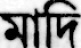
মাদি
